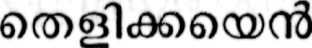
തെളിക്കയെന്‍
